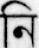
নি
